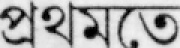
প্রথমতে
